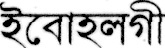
ইবোহলগী
